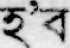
হ'ব
